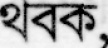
থবক,
